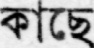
কাছে
